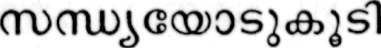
സന്ധ്യയോടുകൂടി
